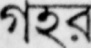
গহর
